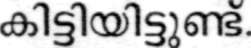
കിട്ടിയിട്ടുണ്ട്.
